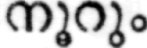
നൂറും
